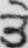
ਤੇ
